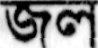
জল
